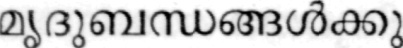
മൃദുബന്ധങ്ങള്‍ക്കു
